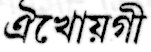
ঐখোয়গী
